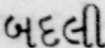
બદલી
